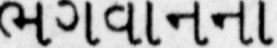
ભગવાનના
